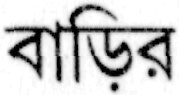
বাড়ির
